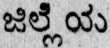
ಜಿಲ್ಲೆಯ
